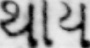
થાય
